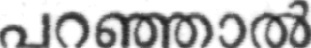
പറഞ്ഞാല്‍
